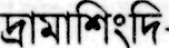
দ্রামাশিংদি
